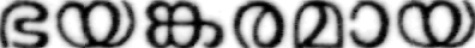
ഭയങ്കരമായ
